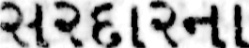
સરદારના
